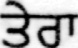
ਤੇਰਾ
